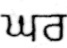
ਘਰ
